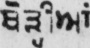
ਥੋੜ੍ਹੀਆਂ
